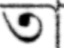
তা
